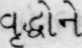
વૃદ્ધોને
